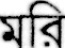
মরি
